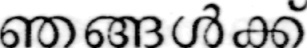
ഞങ്ങള്‍ക്ക്
